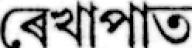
ৰেখাপাত
